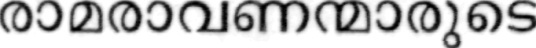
രാമരാവണന്മാരുടെ
